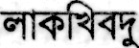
লাকখিবদু
